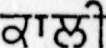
ਕਾਲੀ
